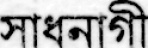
সাধনাগী
